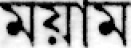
ময়াম
